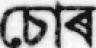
চোৰ
